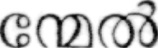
ന്മേല്‍
